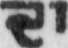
ਦਾ
